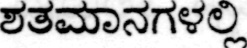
ಶತಮಾನಗಳಲ್ಲಿ
